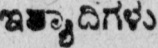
ಇತ್ಯಾದಿಗಳು
